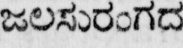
ಜಲಸುರಂಗದ
